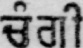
ਚੰਗੀ
